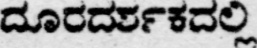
ದೂರದರ್ಶಕದಲ್ಲಿ
